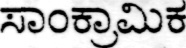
ಸಾಂಕ್ರಾಮಿಕ
